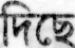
দিছে
